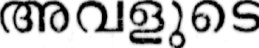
അവളുടെ
